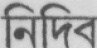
নিদিব
